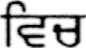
ਵਿਚ
